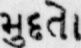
મુદતો
